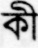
কী
